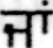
ਜਾਂ
